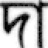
দা
